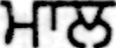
ਮਾਲ
